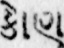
કોણ
